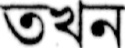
তখন
